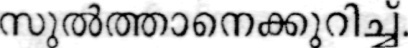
സുല്‍ത്താനെക്കുറിച്ച്,
